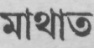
মাথাত
